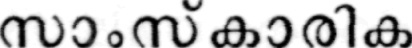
സാംസ്കാരിക
